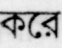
করে
